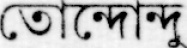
তোন্দোন্দু
